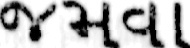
જમવા
